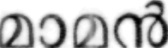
മാമന്‍
